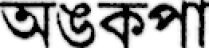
অঙকপা
